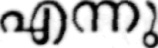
എന്നു
